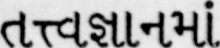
તત્ત્વજ્ઞાનમાં
